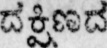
ದಕ್ಷಿಣದ
